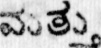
ಮತ್ತು
